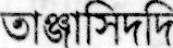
তাঞ্জাসিদদি
